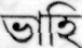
ভাহি
